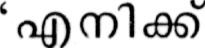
‘എനിക്ക്
